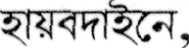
হায়বদাইনে,
